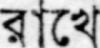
রাখে
